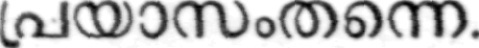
പ്രയാസംതന്നെ.
